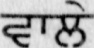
ਵਾਲੇ
